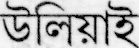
উলিয়াই
